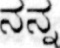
ನನ್ನ
